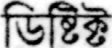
ডিষ্টিক্ট
